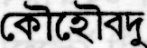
কৌহৌবদু
